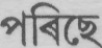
পৰিছে
